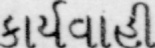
કાર્યવાહી
